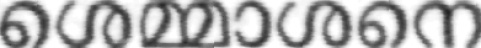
ശെമ്മാശനെ
